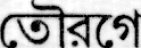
তৌরগে
